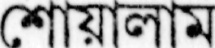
শোয়ালাম
